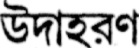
উদাহরণ
